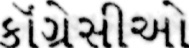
કૉંગ્રેસીઓ
